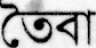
তৈবা
